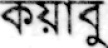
কয়াবু
